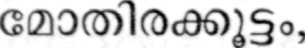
മോതിരക്കൂട്ടം,
